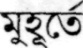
মুহূর্তে
